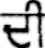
ਦੀ
